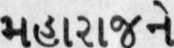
મહારાજને
